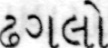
ઢગલો
